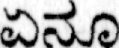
ಏನೂ
